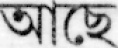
আছে
